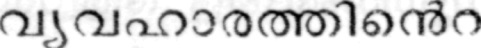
വ്യവഹാരത്തിന്റെ
